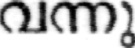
വന്നു
